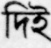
দিই
